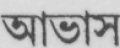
আভাস
